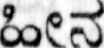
ಹೀನ
